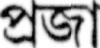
প্রজা
